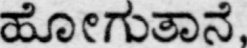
ಹೋಗುತಾನೆ,
